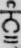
ਨੂੰ
